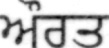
ਔਰਤ
